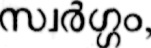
സ്വര്‍ഗ്ഗം,
